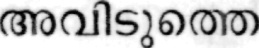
അവിടുത്തെ
